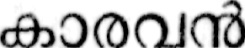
കാരവന്‍
